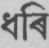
ধৰি
